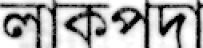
লাকপদা
